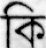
কি
